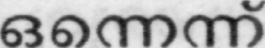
ഒന്നെന്ന്
